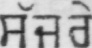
ਸੱਜਰੇ
